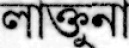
লাক্তুনা
